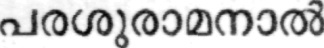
പരശുരാമനാല്‍
